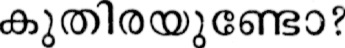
കുതിരയുണ്ടോ?
